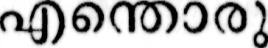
എന്തൊരു
